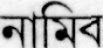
নামিব
